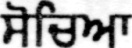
ਸੋਚਿਆ
